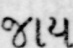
જાય
